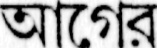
আগের
